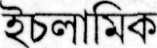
ইচলামিক
